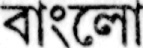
বাংলো
